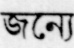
জন্যে
